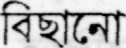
বিছানো
